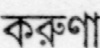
করুণা
